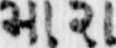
મારા
